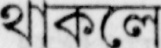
থাকলে
